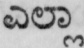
ಎಲ್ಲಾ
